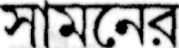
সামনের
